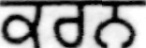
ਕਰਨ
